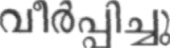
വീര്‍പ്പിച്ചു
